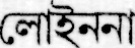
লোইননা
